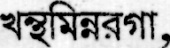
খন্থমিন্নরগা,
